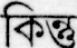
কিন্তু
